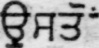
ਉਸਤੋਂ,
